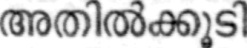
അതില്‍ക്കൂടി
